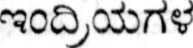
ಇಂದ್ರಿಯಗಳ
